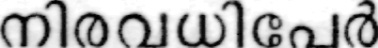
നിരവധിപേര്‍
